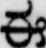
ಈ
